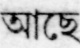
আছে
